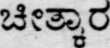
ಚೀತ್ಕಾರ
